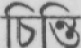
চিন্তি
